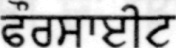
ਫੌਰਸਾਈਟ
